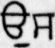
ਉਸ
